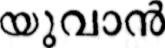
യുവാന്‍
